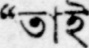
‘‘তাই
